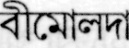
বীমোলদা
